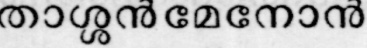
താശ്ശന്‍മേനോന്‍
